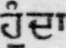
ਹੁੰਦਾ
